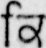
ਕਿ
